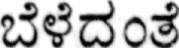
ಬೆಳೆದಂತೆ
